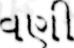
વણી
